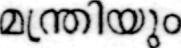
മന്ത്രിയും
